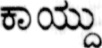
ಕಾಯ್ದು
